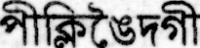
পীক্লিঙৈদগী
